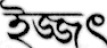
ইজ্জৎ
